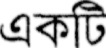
একটি
